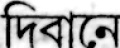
দিবানে
